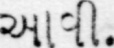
આવી.
